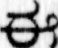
ಈ
